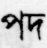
পদ
